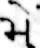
મેં
